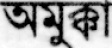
অমুক্কা
